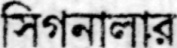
সিগনালার
